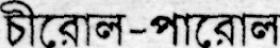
চীরোল-পারোল
